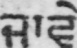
ਜਾਵੇ
